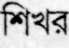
শিখর
